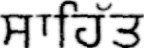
ਸਾਹਿੱਤ
